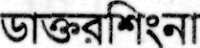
ডাক্তরশিংনা
